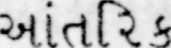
આંતરિક
